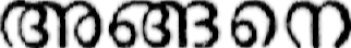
അങ്ങനെ
